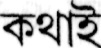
কথাই
